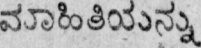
ಮಾಹಿತಿಯನ್ನು
